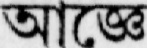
আজ্ঞে
